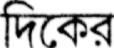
দিকের
